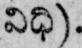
ವಿಧಿ).
